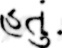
હતું.
